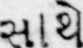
સાથે
